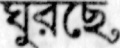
ঘুরছে,
